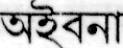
অইবনা
